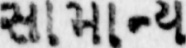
સામાન્ય
